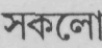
সকলো
